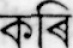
কৰি
